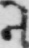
ને
